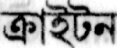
ক্রাইটন
